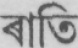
ৰাতি
